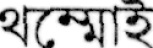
থম্মোই
